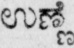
ಉಣ್ಣೆ
